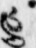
હું
